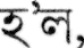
হ'ল,
